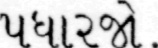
પધારજો.
